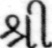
શ્રી
